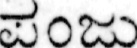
ಪಂಜು
